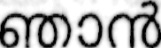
ഞാന്‍
